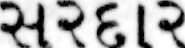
સરદાર
